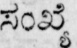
ಸಂಖ್ಯೆ
